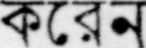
করেন
